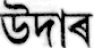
উদাৰ
